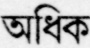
অধিক
